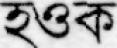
হওক
